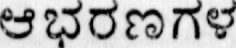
ಆಭರಣಗಳ
